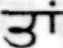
ਤਾਂ
